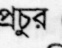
প্রচুর
